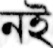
নই
